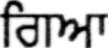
ਗਿਆ
